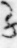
કે
